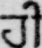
ਹੀ
